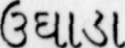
ઉઘાડા
